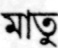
মাতু
